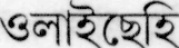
ওলাইছেহি
